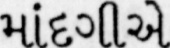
માંદગીએ
